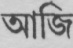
আজি
